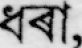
ধৰা,
